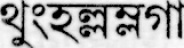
থুংহল্লম্লগা
